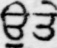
ਉਤੇ
